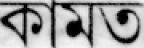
কামত
